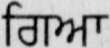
ਗਿਆ
